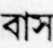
বাস
